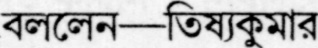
বললেন–তিষ্যকুমার
